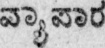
ವ್ಯಾಪಾರ
